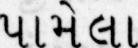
પામેલા
